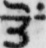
ਤੋਂ
